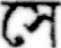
সে
